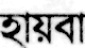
হায়বা
